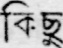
কিছু
